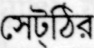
সেট্ঠির
